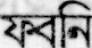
ফবনি
